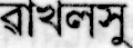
ৱাখলসু
